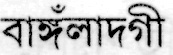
বাঙ্গঁলাদগী
